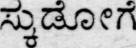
ಸ್ಕುಡೋಗೆ
